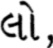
લો,
